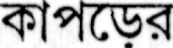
কাপড়ের
